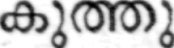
കുത്തു
